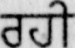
ਰਹੀ
